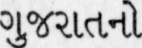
ગુજરાતનો
